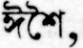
ঈশৈ,
